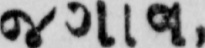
જગાવ,
